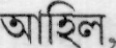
আহিল,
